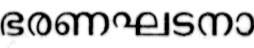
ഭരണഘടനാ
